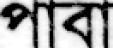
পাবা
